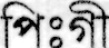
পিঃগী
